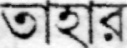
তাহার
